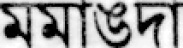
মমাঙদা
